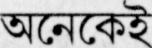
অনেকেই
